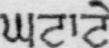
ਘਟਾਟੇ
